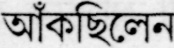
আঁকছিলেন
